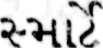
સ્માર્ટે
